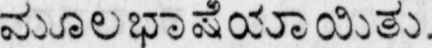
ಮೂಲಭಾಷೆಯಾಯಿತು.
